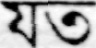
যত
